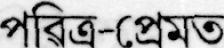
পৱিত্র-প্রেমত
